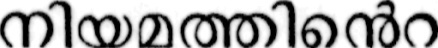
നിയമത്തിന്റെ
